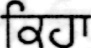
ਕਿਹਾ
